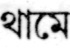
থামে
